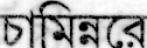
চামিন্নরে
